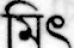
মিৎ
